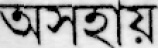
অসহায়
